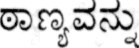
ಠಾಣ್ಯವನ್ನು
